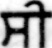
ਸੀ
